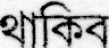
থাকিব
